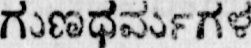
ಗುಣಧರ್ಮಗಳ
